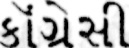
કૉંગ્રેસી
